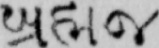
બ્રહ્મજ
